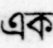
এক
